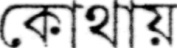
কোথায়
